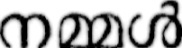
നമ്മള്‍
